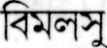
বিমলসু
